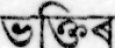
ভক্তিৰ
